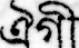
ঐগী
